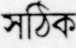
সঠিক
